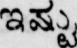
ಇಷ್ಟು
